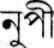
নুপী
